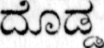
ದೊಡ್ಡ
